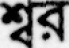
শ্বর
